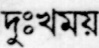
দুঃখময়
